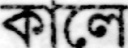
কালে
